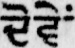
ਦੋਵੇਂ
